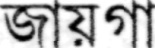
জায়গা
